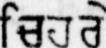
ਚਿਹਰੇ
